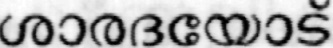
ശാരദയോട്
